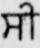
ਸੀ
